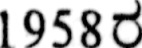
1958ರ
